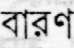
বারণ
